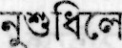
নুশুধিলে
